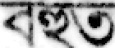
বহুত
